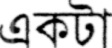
একটা
